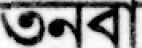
তনবা
